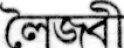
লৈজবী
